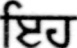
ਇਹ
